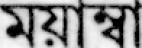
ময়াম্বা
